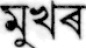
মুখৰ
